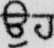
ਉਹ
